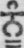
ਨੂੰ
